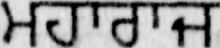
ਮਹਾਰਾਜ
